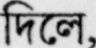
দিলে,
